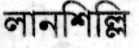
লানশিল্লি
